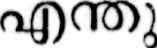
എന്തു
